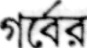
গর্বের
